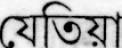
যেতিয়া
